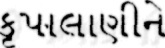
કૃપાલાણીને
